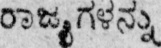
ರಾಜ್ಯಗಳನ್ನು
